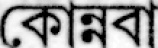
কোন্নবা
